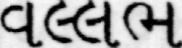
વલ્લભ
